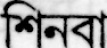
শিনবা
